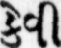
કેવી
